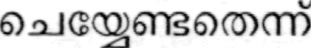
ചെയ്യേണ്ടതെന്ന്
